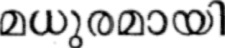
മധുരമായി
